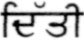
ਦਿੱਤੀ
